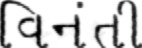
વિનંતી
